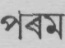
পৰম
